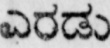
ಎರಡು
